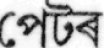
পেটৰ
